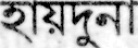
হায়দুনা
